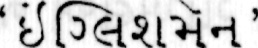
'ઇંગ્લિશમૅન'
